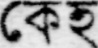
কেহ
